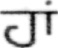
ਹਾਂ
